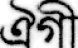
ঐগী
